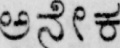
ಅನೇಕ
